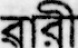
ৱারী
